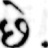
છે.
